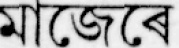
মাজেৰে
